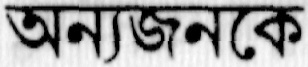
অন্যজনকে
